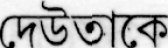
দেউতাকে
